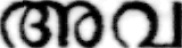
അവ
